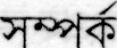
সম্পর্ক
